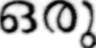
ഒരു
